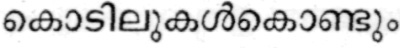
കൊടിലുകള്‍കൊണ്ടും
